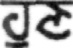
ਹੁਣ
